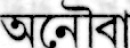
অনৌবা
